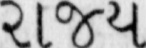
રાજ્ય
